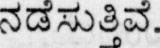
ನಡೆಸುತ್ತಿವೆ.
